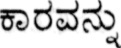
ಕಾರವನ್ನು
